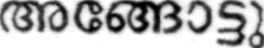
അങ്ങോട്ടു
